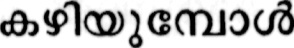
കഴിയുമ്പോള്‍
